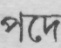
পদে
